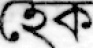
হেক
